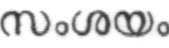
സംശയം
